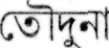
তৌদুনা
